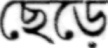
ছেড়ে
